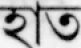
হাত
